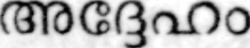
അദ്ദേഹം
